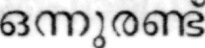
ഒന്നുരണ്ട്
